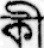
কী
